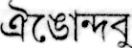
ঐঙোন্দবু
